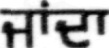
ਜਾਂਦਾ
